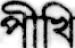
পীখি
